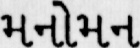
મનોમન
